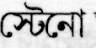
স্টেনো
